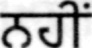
ਨਹੀਂ
